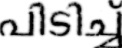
പിടിച്ച്
